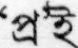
'প্র'ই
